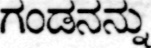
ಗಂಡನನ್ನು
